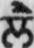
ਲੈ
